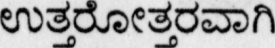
ಉತ್ತರೋತ್ತರವಾಗಿ
